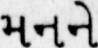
મનને
